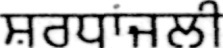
ਸ਼ਰਧਾਂਜਲੀ
